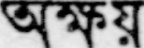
অক্ষয়
